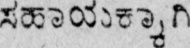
ಸಹಾಯಕ್ಕಾಗಿ
